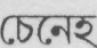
চেনেহ
